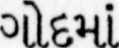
ગોદમાં
